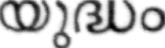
യുദ്ധം
